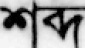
শব্দ
